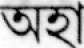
অহা
